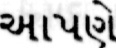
આપણે
